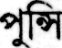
পুন্সি
